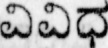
ವಿವಿಧ
